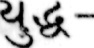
યુદ્ધ-
